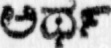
ಅರ್ಥ
